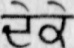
ਦੇਕੇ
